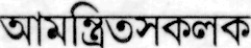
আমন্ত্রিতসকলক
